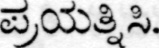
ಪ್ರಯತ್ನಿಸಿ.
